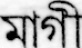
মাগী
